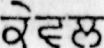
ਕੇਵਲ
